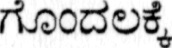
ಗೊಂದಲಕ್ಕೆ
